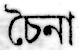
চৈনা
